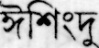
ঈশিংদু
